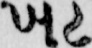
ખટ
